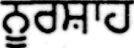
ਨੂਰਸ਼ਾਹ
